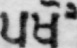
ਪਖੋਂ
